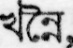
খন্নৈ,
